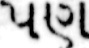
પણ
